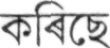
কৰিছে
